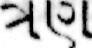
ત્રણ
